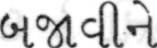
બજાવીને
